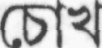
চোখ
